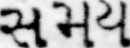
સમય
